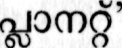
പ്ലാനറ്റ്'
